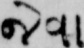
જેવા
